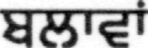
ਬਲਾਵਾਂ
